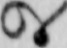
જ
